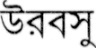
উরবসু
